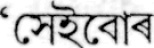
'সেইবোৰ
